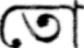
তো
